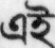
এই
